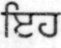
ਇਹ
